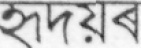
হৃদয়ৰ
